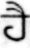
ਹੈ
